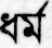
ধর্ম
